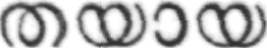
തയായ
